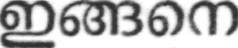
ഇങ്ങനെ
